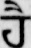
ਹੈ
